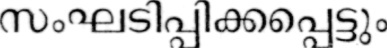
സംഘടിപ്പിക്കപ്പെട്ടും
